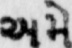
અમે
